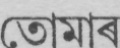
তোমাৰ
